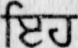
ਇਹ
